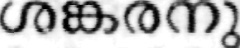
ശങ്കരനു
